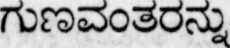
ಗುಣವಂತರನ್ನು
